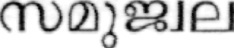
സമുജ്വല
